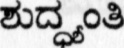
ಶುದ್ಧ್ಯಂತಿ
